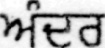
ਅੰਦਰ
